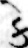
કે
